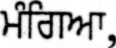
ਮੰਗਿਆ,
